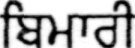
ਬਿਮਾਰੀ
